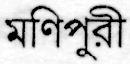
মণিপুরী
